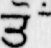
ਤੋਂ
